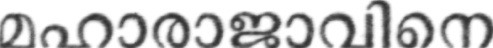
മഹാരാജാവിനെ
